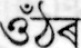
ওঁঠৰ
